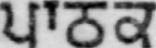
ਪਾਠਕ
